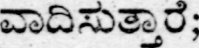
ವಾದಿಸುತ್ತಾರೆ;
